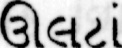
ઊલટાં
